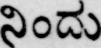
ನಿಂದು
